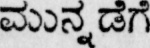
ಮುನ್ನಡೆಗೆ
